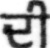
ਦੀ
